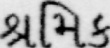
શ્રમિક
